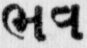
ભવ
